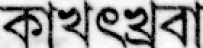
কাখৎখ্রবা
